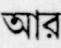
আর
